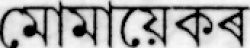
মোমায়েকৰ
